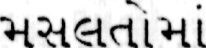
મસલતોમાં
